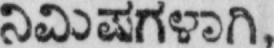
ನಿಮಿಷಗಳಾಗಿ,
